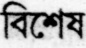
বিশেষ
